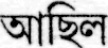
আছিল
